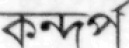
কন্দর্প
